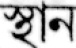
স্থান
